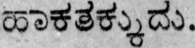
ಹಾಕತಕ್ಕುದು.
